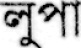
লুপা
